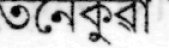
তেনেকুৱা
